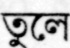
তুলে
